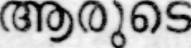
ആരുടെ
